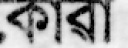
কোৱা
